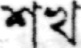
শখ
